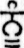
ਨੂੰ
